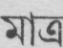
মাত্ৰ
